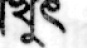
মখুৎ
